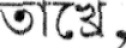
তাখ্রে,
